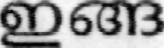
ഇങ്ങ
